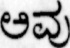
ಅವು
